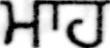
ਮਾਹ
